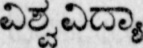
ವಿಶ್ವವಿದ್ಯಾ
